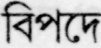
বিপদে
